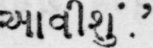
આવીશું.'
